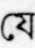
যে
